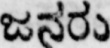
ಜನರು
